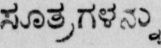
ಸೂತ್ರಗಳನ್ನು
